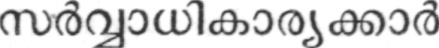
സര്‍വ്വാധികാര്യക്കാര്‍
